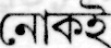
নোকই
